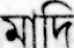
মাদি
